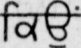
ਕਿਉਂ
